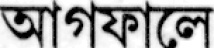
আগফালে
